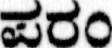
ಪರಂ
